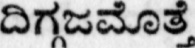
ದಿಗ್ಗಜಮೊತ್ತೆ
